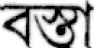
বস্তা
